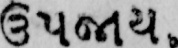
ઉપજાય.
